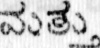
ಮತ್ತು
